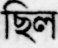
ছিল
